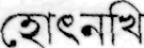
হোৎনখি
